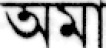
অমা
